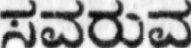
ಸವರುವ
